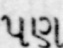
પણ
